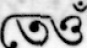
তেওঁ
